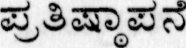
ಪ್ರತಿಷ್ಠಾಪನೆ
